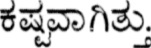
ಕಷ್ಟವಾಗಿತ್ತು.
